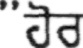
''ਹੋਰ
